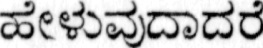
ಹೇಳುವುದಾದರೆ
